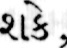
શકે,
